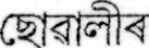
ছোৱালীৰ
